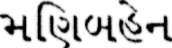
મણિબહેન
